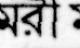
মেরী
